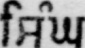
ਸਿੰਘ
